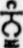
ਨੂੰ
